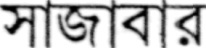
সাজাবার
